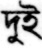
দুই
